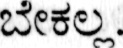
ಬೇಕಲ್ಲ.
